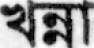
খন্না
